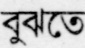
বুঝতে
